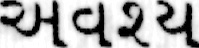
અવશ્ય
